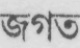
জগত
